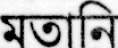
মতানি
